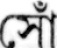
সোঁ
